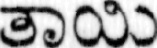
ತಾಯಿ
